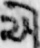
એ
